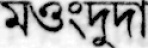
মওংদুদা
